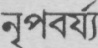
নৃপবৰ্য্য
